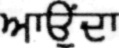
ਆਉਂਦਾ
